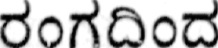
ರಂಗದಿಂದ
